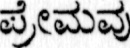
ಪ್ರೇಮವು
